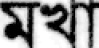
মখা
